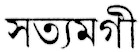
সত্যমগী
